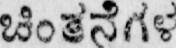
ಚಿಂತನೆಗಳ
